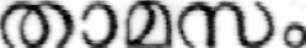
താമസം
